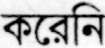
করেনি
